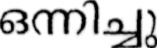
ഒന്നിച്ചു
